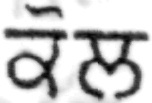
ਕੋਲ
